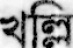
খল্লি
